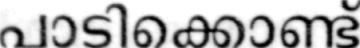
പാടിക്കൊണ്ട്
